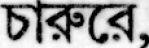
চারুরে,
